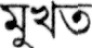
মুখত
